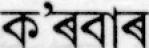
ক'ৰবাৰ
